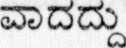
ವಾದದ್ದು
